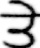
ਤੇ
